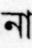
না
